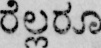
ರೆಲ್ಲರೂ
